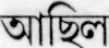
আছিল
